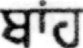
ਬਾਂਹ
